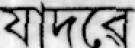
যাদৱে
